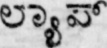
ಲ್ಯಾಪ್
